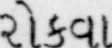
રોકવા
